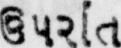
ઉપરાંત
